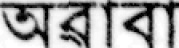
অৱাবা
